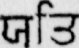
ਯਤਿ
